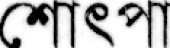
শোৎপা
